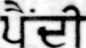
ਪੈਂਦੀ
